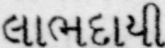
લાભદાયી
